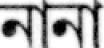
নানা
